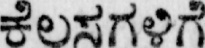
ಕೆಲಸಗಳಿಗೆ
